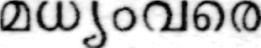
മധ്യംവരെ
